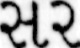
સર
